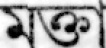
মক্তা
